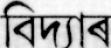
বিদ্যাৰ
